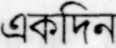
একদিন
